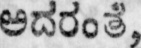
ಅದರಂತೆ,
